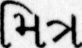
મિત્ર
